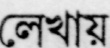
লেখায়
